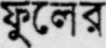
ফুলের
